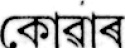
কোৱাৰ
